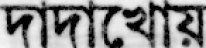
দাদাখোয়
